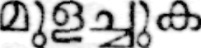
മുളച്ചുക
